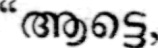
“ആട്ടെ,
